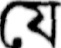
যে
